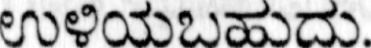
ಉಳಿಯಬಹುದು.
